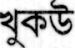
খুকউ
